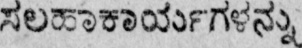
ಸಲಹಾಕಾರ್ಯಗಳನ್ನು
